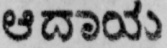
ಆದಾಯ
